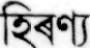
হিৰণ্য
